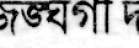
জিঙ্ঘগী
